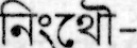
নিংথৌ-
